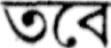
তবে
